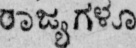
ರಾಜ್ಯಗಳೂ
